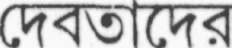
দেবতাদের
